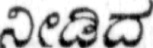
ನೀಡಿದ
